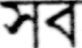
সব
